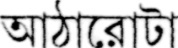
আঠারোটা
